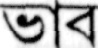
ভাব
